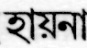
হায়না
